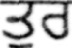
ਤੁਰ
